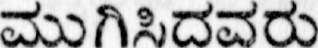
ಮುಗಿಸಿದವರು
